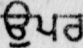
ਉਪਰ
